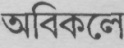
অবিকলে
